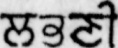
ਲਭਣੀ
